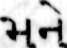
મને
